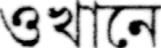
ওখানে
